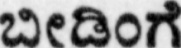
ಬೀಡಿಂಗೆ
